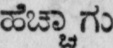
ಹೆಚ್ಚಾಗು
